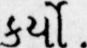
કર્યો.
